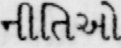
નીતિઓ
